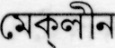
মেক্‌লীন
